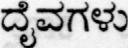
ದೈವಗಳು
